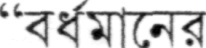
“বর্ধমানের
